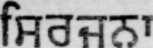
ਸਿਰਜਨਾ
